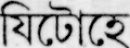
যিটোহে
